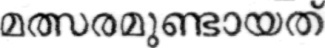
മത്സരമുണ്ടായത്
